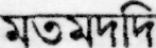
মতমদদি
